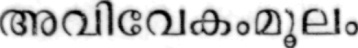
അവിവേകംമൂലം
